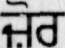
ਜ਼ੋਰ
